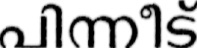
പിന്നീട്
